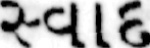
સ્વાદ
